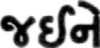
જઈને
